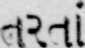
તરતાં
